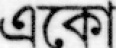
একো
